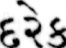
દરેક
